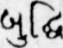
બુદ્ધિ
